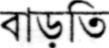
বাড়তি
